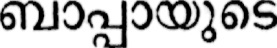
ബാപ്പായുടെ
